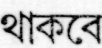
থাকবে
